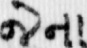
જેના
